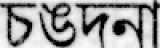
চঙদনা
